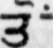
ਤੋਂ
